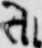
તો
